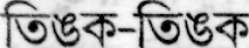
তিঙক-তিঙক
